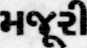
મજૂરી
